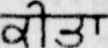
ਕੀਤਾ
